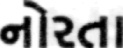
રે...માના
